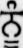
ਨੂੰ
